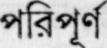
পরিপূর্ণ
